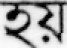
হয়
